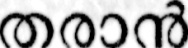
തരാന്‍
